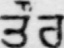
ਤੌਰ
